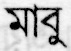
মাবু
